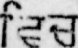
ਵਿਚ
